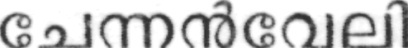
ചേന്നന്‍വേലി
